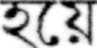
হয়ে
